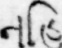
નહિ
